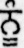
ਨੂੰ
